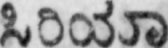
ಸಿರಿಯಾ
